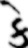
કે
